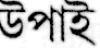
উপাই
